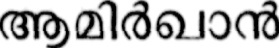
ആമിര്‍ഖാന്‍
